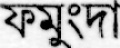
ফমুংদা
